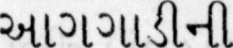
આગગાડીની
